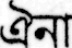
ঐনা
